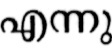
എന്നു
